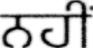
ਨਹੀਂ
